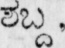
ಶಬ್ದ,
